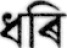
ধৰি
